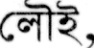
লৌই,
